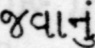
જવાનું
